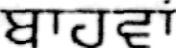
ਬਾਹਵਾਂ
